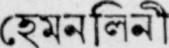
হেমনলিনী
